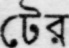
টের
